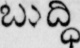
ಬುದ್ಧಿ
